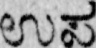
ಉಪ
